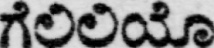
ಗೆಲಿಲಿಯೊ
